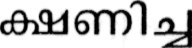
ക്ഷണിച്ച
